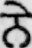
ਨੇ
